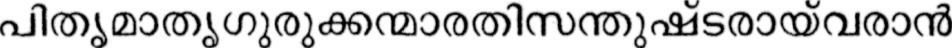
പിതൃമാതൃഗുരുക്കന്മാരതിസന്തുഷ്ടരായ്വരാന്‍
